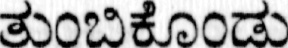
ತುಂಬಿಕೊಂಡು
